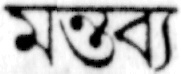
মন্তব্য
